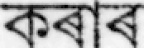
কৰাৰ
